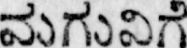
ಮಗುವಿಗೆ
